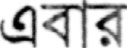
এবার
